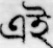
এই
